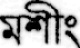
মশীং
